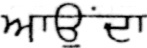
ਆਉਂਦਾ
